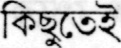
কিছুতেই
